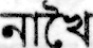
নাখৈ
